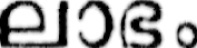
ലാഭം
